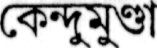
কেন্দুমুণ্ডা
